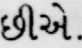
છીએ.
